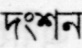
দংশন
